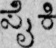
ಪೈಕಿ
